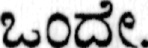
ಒಂದೇ.
